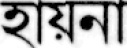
হায়না
